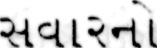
સવારનો
